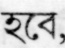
হবে,
